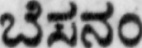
ಬೆಸನಂ
